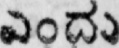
ಎಂದು
